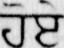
ਹੋਏ
